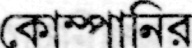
কোম্পানির
